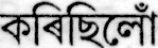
কৰিছিলোঁ
